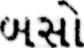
બસો
